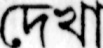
দেখা
